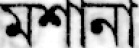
মশানা
